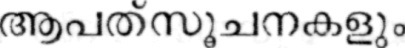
ആപത്സൂചനകളും
